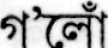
গ'লোঁ
